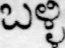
ಬಳ್ಳಿ
